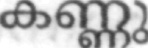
കണ്ണു
